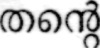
തന്റെ
